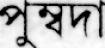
পুম্বদা
